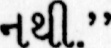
નથી."
